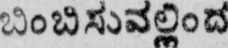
ಬಿಂಬಿಸುವಲ್ಲಿಂದ
